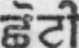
ਛੋਟੀ
